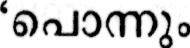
‘പൊന്നും
